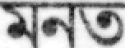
মনত
